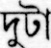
দুটা
